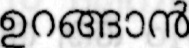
ഉറങ്ങാന്‍
